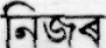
নিজৰ
